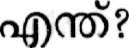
എന്ത്?
